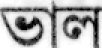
ভাল
